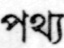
পথ্য
